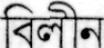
বিলীন
